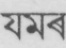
যমৰ
